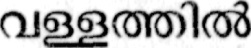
വള്ളത്തില്‍
